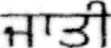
ਜਾਤੀ
